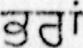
ਭਰਾਂ
